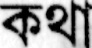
কথা
